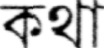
কথা
